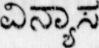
ವಿನ್ಯಾಸ
